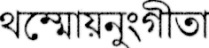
থম্মোয়নুংগীতা
